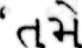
'તમે
